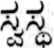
ಸ್ವಸ್ಥ
